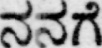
ನನಗೆ
